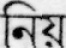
নিয়
